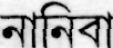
নানিবা
